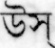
উস্
